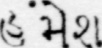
હંમેશ
